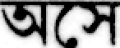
অসে
